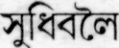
সুধিবলৈ
